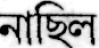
নাছিল
